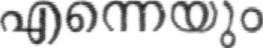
എന്നെയും
